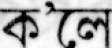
ক'লে
